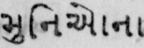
મુનિઓના
